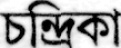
চন্দ্রিকা
